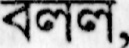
বলল,
